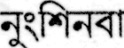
নুংশিনবা
